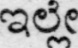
ಇಲ್ಲೇ
